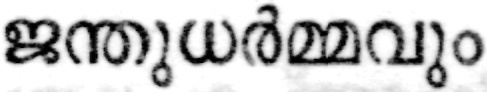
ജന്തുധര്‍മ്മവും
